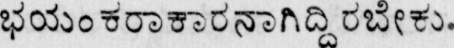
ಭಯಂಕರಾಕಾರನಾಗಿದ್ದಿರಬೇಕು.
